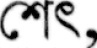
শেৎ,
